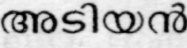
അടിയന്‍
